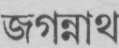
জগন্নাথ
